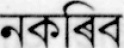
নকৰিব
